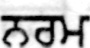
ਨਰਮ
